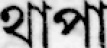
থাপা
